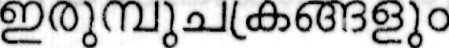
ഇരുമ്പുചക്രങ്ങളും
